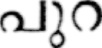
പുറ
